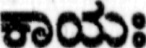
ಕಾಯಃ
